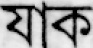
যাক
